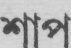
শাপ
